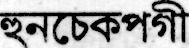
হুনচেকপগী
